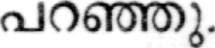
പറഞ്ഞു.
